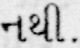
નથી.
